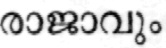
രാജാവും
